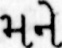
મને
